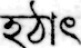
হঠাৎ
